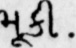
મૂકી.
